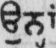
ਉਨ੍ਹਾਂ
